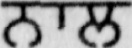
ਨਾਲ
